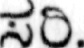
ಸರಿ.
